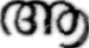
ആ
